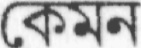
কেমন
